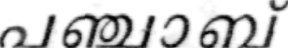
പഞ്ചാബ്
